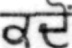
ਕਦੋਂ
